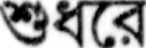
শুধরে
